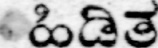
ಹಿಡಿತ
